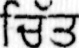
ਚਿੱਤ
